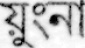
য়ুংনা
